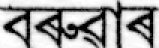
বৰুৱাৰ
